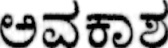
ಅವಕಾಶ
